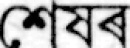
শেষৰ
